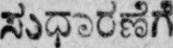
ಸುಧಾರಣೆಗೆ
